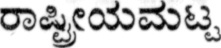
ರಾಷ್ಟ್ರೀಯಮಟ್ಟ
